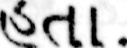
હતા.
